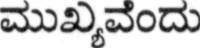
ಮುಖ್ಯವೆಂದು
